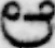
ಆ
